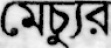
মোচ্যুর
